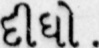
દીધો.
